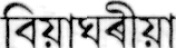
বিয়াঘৰীয়া
